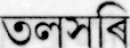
তলসৰি
